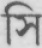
সি
